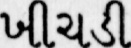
ખીચડી
